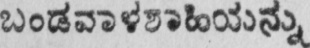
ಬಂಡವಾಳಶಾಹಿಯನ್ನು
